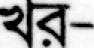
খর-
